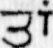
ਤਾਂ
